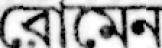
রোমেন
